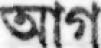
আগ
